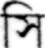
সি
